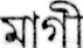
মাগী
